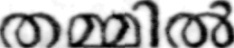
തമ്മില്‍
